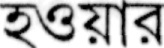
হওয়ার
